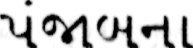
પંજાબના
